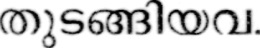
തുടങ്ങിയവ.
